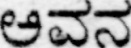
ಅವನ
